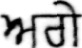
ਅਗੇ
